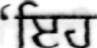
'ਇਹ
